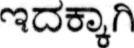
ಇದಕ್ಕಾಗಿ
